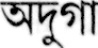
অদুগা
